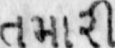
તમારી
